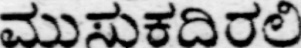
ಮುಸುಕದಿರಲಿ
